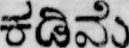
ಕಡಿಮೆ
